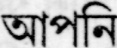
আপনি
